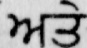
ਅਤੇ
